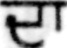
ਦਾ
